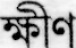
ক্ষীণ
